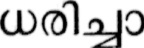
ധരിച്ചാ
